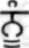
ਨੂੰ
